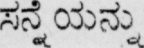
ಸನ್ನೆಯನ್ನು
